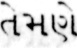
તેમણે
